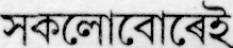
সকলোবোৰেই
